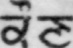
ਕੌਣ
